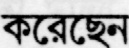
করেছেন
